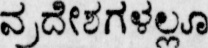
ಪ್ರದೇಶಗಳಲ್ಲೂ
